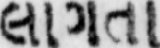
લાગતા
